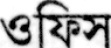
ওফিস
